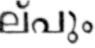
ല്പും
